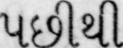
પછીથી
